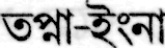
তপ্না-ইংনা
